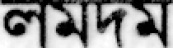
লমদম
